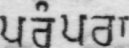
ਪਰੰਪਰਾ
